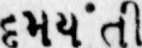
દમયંતી
